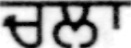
ਚਲਾ
